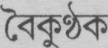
বৈকুণ্ঠক
